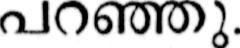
പറഞ്ഞു.
